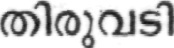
തിരുവടി
